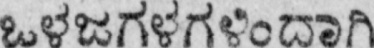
ಒಳಜಗಳಗಳಿಂದಾಗಿ
